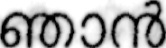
ഞാന്‍
